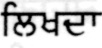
ਲਿਖਦਾ
